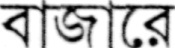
বাজারে
